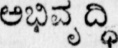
ಅಭಿವೃದ್ಧಿ
